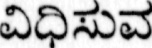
ವಿಧಿಸುವ
